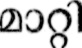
മാറ്റി
